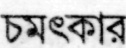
চমত্কার
